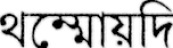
থম্মোয়দি
